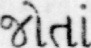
જોતાં
